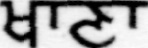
ਖਾਣਾ
